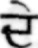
ਦੇ
